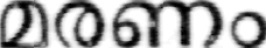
മരണം
